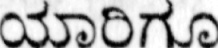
ಯಾರಿಗೂ
